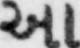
આ
